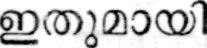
ഇതുമായി
